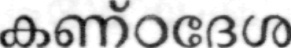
കണ്ഠദേശ
